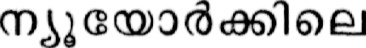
ന്യൂയോര്‍ക്കിലെ
